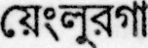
য়েংলুরগা
